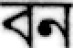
বন
